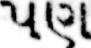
પણ
